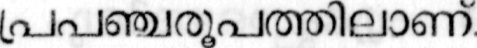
പ്രപഞ്ചരൂപത്തിലാണ്.
